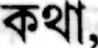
কথা,
